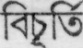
বিচূর্তি
